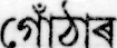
গোঁঠাৰ
